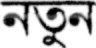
নতুন
